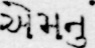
એમનું
